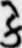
કે
